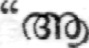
“ആ
